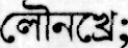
লৌনখ্রে;
